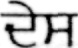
ਦੇਸ
